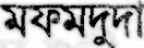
মফমদুদা
